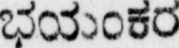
ಭಯಂಕರ
